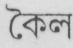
কৈল
